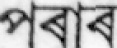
পৰাৰ
